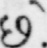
છે.
